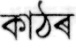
কাঠৰ
